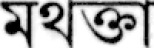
মথক্তা
